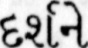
દર્શને
